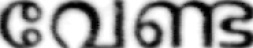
വേണ്ട
